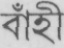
বাঁহী
